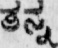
ತನ್ನ
